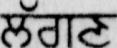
ਲੱਗਣ
